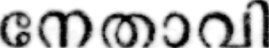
നേതാവി
